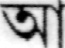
আ
